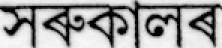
সৰুকালৰ
